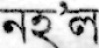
নহ'ল
